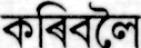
কৰিবলৈ
